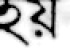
হয়
